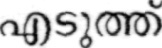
എടുത്ത്
